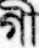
গী
